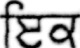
ਇਕ
